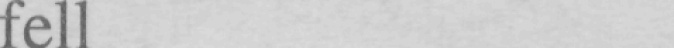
fell
